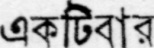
একটিবার
